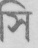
সি
